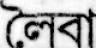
লৈবা
